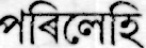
পৰিলেহি
